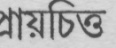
প্ৰায়চিত্ত
